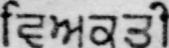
ਵਿਅਕਤੀ
